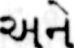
અને
